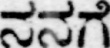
ನನಗೆ
